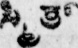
ಸ್ಮಿತ್
